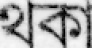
থকা
